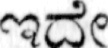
ಇದೇ
